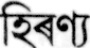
হিৰণ্য
